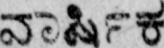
ವಾರ್ಷಿಕ
